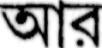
আর
